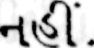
નહીં.
